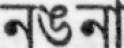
নঙনা
